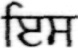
ਇਸ
